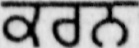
ਕਰਨ
